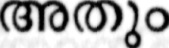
അതും
